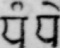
ਧੰਧੇ
